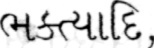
ભક્ત્યાદિ,
